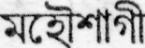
মহৌশাগী
